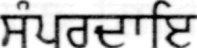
ਸੰਪਰਦਾਇ
